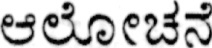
ಆಲೋಚನೆ
